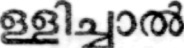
ള്ളിച്ചാല്‍
